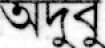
অদুবু
